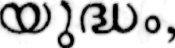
യുദ്ധം,
